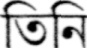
তিনি
